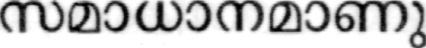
സമാധാനമാണു
